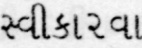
સ્વીકારવા
